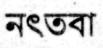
নৎতবা
